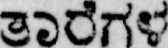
ತಾರೆಗಳ
